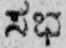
ಸಭ
